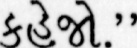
કહેજો."
